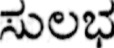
ಸುಲಭ
